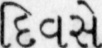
દિવસે
